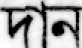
দান
